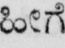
ಹೀಗೆ
